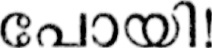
പോയി!
